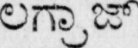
ಲಗ್ರಾಜ್
